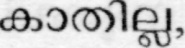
കാതില്ല,
